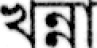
খন্না
